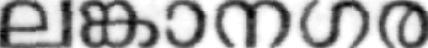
ലങ്കാനഗര
